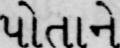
પોતાને
